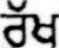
ਰੱਖ
